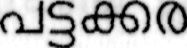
പട്ടക്കര
